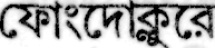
ফোংদোক্লুরে
